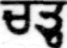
ਚੜ੍ਹ
